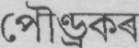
পৌন্ড্ৰকৰ
